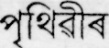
পৃথিৱীৰ
